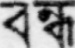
বন্ধ
